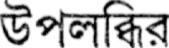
উপলব্ধির
